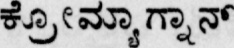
ಕ್ರೋಮ್ಯಾಗ್ನಾನ್
